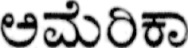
ಅಮೆರಿಕಾ
